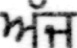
ਅੱਜ
